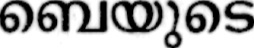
ബെയുടെ
